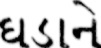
ઘડાને
